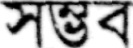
সম্ভব
